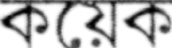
কয়েক
